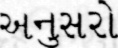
અનુસરો
